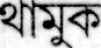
থামুক
